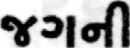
જગની
